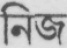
নিজ
